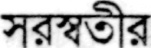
সরস্বতীর
